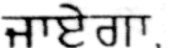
ਜਾਏਗਾ,
